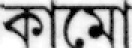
কামো
